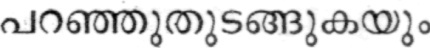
പറഞ്ഞുതുടങ്ങുകയും
